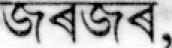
জৰজৰ,
